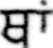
ਥਾਂ
